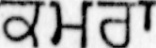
ਕਮਰਾ
